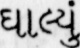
ઘાલ્યું
